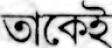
তাকেই
